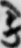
કે
